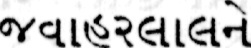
જવાહરલાલને
